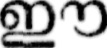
ഈ
